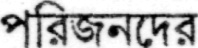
পরিজনদের
